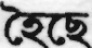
হৈছে
